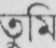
তুমি
